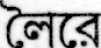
লৈরে
